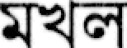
মখল
